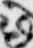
છે
